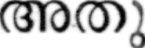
അതു
